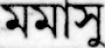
মমাসু
